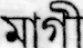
মাগী
